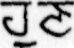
ਹੁਣ
